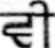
ਵੀ
